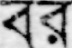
বর
